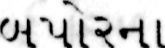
બપોરના
